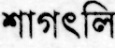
শাগৎলি
